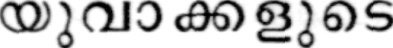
യുവാക്കളുടെ
